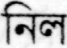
নিল
